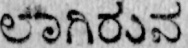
ಲಾಗಿರುವ
